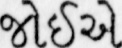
જોઈએ
